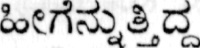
ಹೀಗೆನ್ನುತ್ತಿದ್ದ
